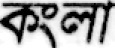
কংলা
